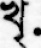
খৃ.
